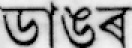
ডাঙৰ
